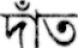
দাঁত
